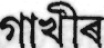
গাখীৰ
